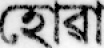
হোৱা
